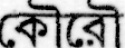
কোরৌ
